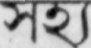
সহ্য
